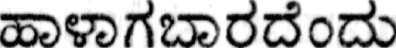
ಹಾಳಾಗಬಾರದೆಂದು
